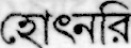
হোৎনরি
